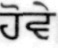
ਹੋਵੇ
